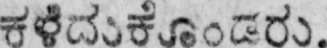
ಕಳೆದುಕೊಂಡರು.
